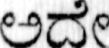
ಅದೇ
